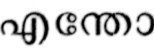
എന്തോ
